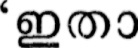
‘ഇതാ
